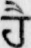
ਹੈ
